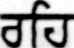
ਰਹਿ
